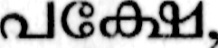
പക്ഷേ,
